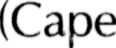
(Cape
